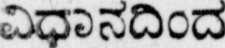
ವಿಧಾನದಿಂದ
